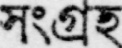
সংগ্রহ
